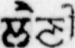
ਲੈਣੀ
